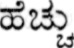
ಹೆಚ್ಚು
